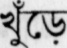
খুঁড়ে
